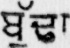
ਬੁੱਢਾ
